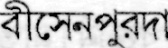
বীসেনপুরদা
